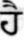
ਹੈ
